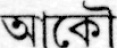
আকৌ
